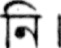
নি।
